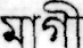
মাগী
